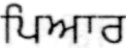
ਪਿਆਰ
